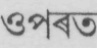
ওপৰত
